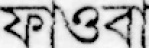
ফাওবা
